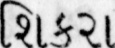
શિકરા
